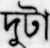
দুটা
